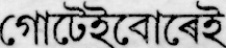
গোটেইবোৰেই
